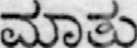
ಮಾತು
